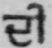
ਦੀ
